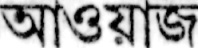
আওয়াজ
